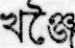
খঞ্জৈ
